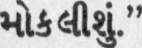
મોકલીશું."
